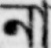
না
